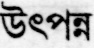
উত্পন্ন
